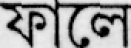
ফালে
